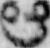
ಆ
